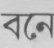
বনে
